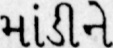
માંડીને
